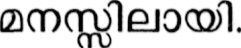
മനസ്സിലായി.
